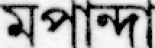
মপান্দা
